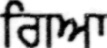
ਗਿਆ
